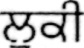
ਲੁਕੀ
